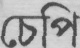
চেপি
